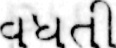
વધતી
